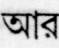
আর
